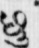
છું
